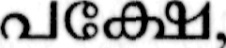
പക്ഷേ,
